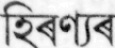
হিৰণ্যৰ
